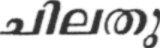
ചിലതു
